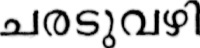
ചരടുവഴി
